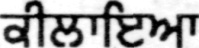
ਕੀਲਾਇਆ
